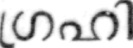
ഗ്രഹി
